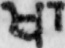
ਖਾ
